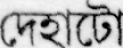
দেহাটো
